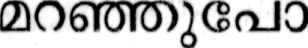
മറഞ്ഞുപോ
